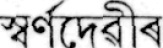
স্বর্ণদেৱীৰ
